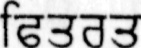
ਫਿਤਰਤ
